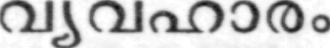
വ്യവഹാരം
